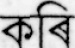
কৰি
